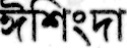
ঈশিংদা
